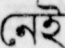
নেই
